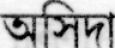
অসিদা
